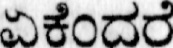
ಏಕೆಂದರೆ
